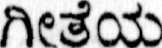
ಗೀತೆಯ
